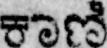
ಕಾಣಿ
